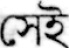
সেই
